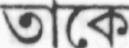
তাকে
